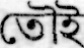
তৌই
